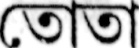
তোতা
